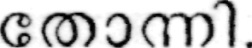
തോന്നി.
